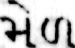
મેળ
